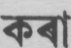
কৰা
